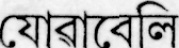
যোৱাবেলি
